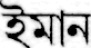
ইমান
